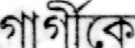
গার্গীকে
